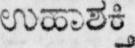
ಉಹಾಶಕ್ತಿ
